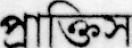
প্রাক্তিস
